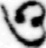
ও
